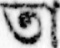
তা
